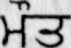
ਮੌਤ
